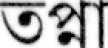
তপ্না
